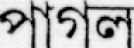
পাগল
